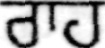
ਰਾਹ
